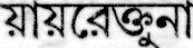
য়ায়রেক্তুনা
